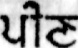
ਪੀਣ
